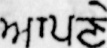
ਆਪਣੇ
